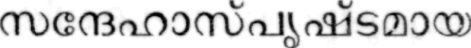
സന്ദേഹാസ്പൃഷ്ടമായ
